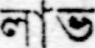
লাভ
